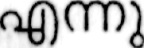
എന്നു
